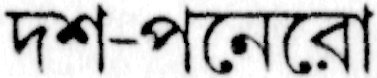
দশ-পনেরো
